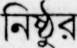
নিষ্ঠুর
